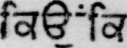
ਕਿਉਂਕਿ
